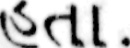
હતા.
